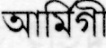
আর্মিগী
